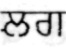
ਲਗ
